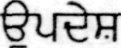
ਉਪਦੇਸ਼
